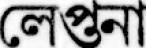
লেপ্তনা
